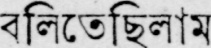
বলিতেছিলাম
